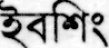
ইবশিং
